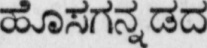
ಹೊಸಗನ್ನಡದ
